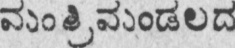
ಮಂತ್ರಿಮಂಡಲದ
